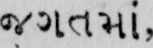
જગતમાં,
